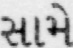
સામે
